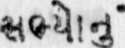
સભ્યોનું
